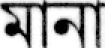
মানা
